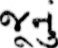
જૂનું
